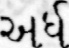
અર્ધ
